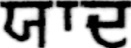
ਯਾਦ
